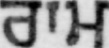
ਰਾਮ
